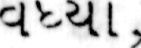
વધ્યા,
